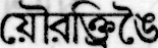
য়ৌরক্ত্রিঙৈ
